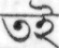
তই
